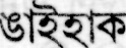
ঙাইহাক
